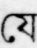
যে
